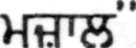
ਮਜ਼ਾਲ''
